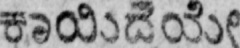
ಕಾಯಿದೆಯೇ
